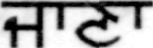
ਜਾਣਾ
